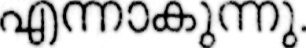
എന്നാകുന്നു.
